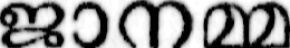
ജാനമ്മ
